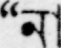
‘‘না
